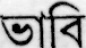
ভাবি
